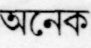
অনেক
